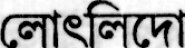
লোৎলিদো
